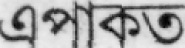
এপাকত
